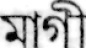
মাগী
